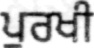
ਪੁਰਖੀ
